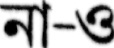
না-ও
